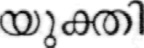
യുക്തി
